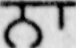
ਨਾ
